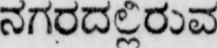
ನಗರದಲ್ಲಿರುವ
